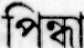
পিন্ধা
